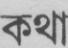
কথা
